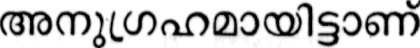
അനുഗ്രഹമായിട്ടാണ്
